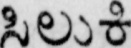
ಸಿಲುಕಿ
